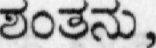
ಶಂತನು,
